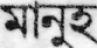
মানুহ
